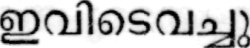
ഇവിടെവച്ചു
